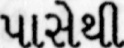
પાસેથી
